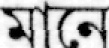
মানে
